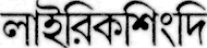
লাইরিকশিংদি
